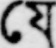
যে
